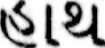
હાથ
